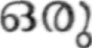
ഒരു
